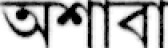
অশাবা
